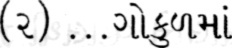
(૨)...ગોકુળમાં
